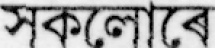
সকলোৰে
